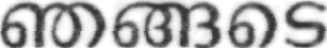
ഞങ്ങടെ
